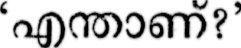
‘എന്താണ്?’
